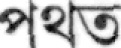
পথত
